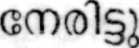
നേരിട്ടു
